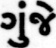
ગુંજે
